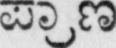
ಪ್ರಾಣ
